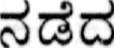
ನಡೆದ
